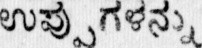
ಉಪ್ಪುಗಳನ್ನು
